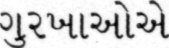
ગુરખાઓએ
